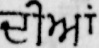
ਦੀਆਂ
